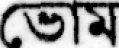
ভোম
